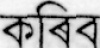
কৰিব
